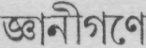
জ্ঞানীগণে
